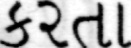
કરતા
